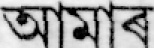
আমাৰ
